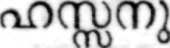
ഹസ്സനു
